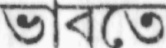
ভাবতে
